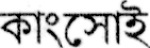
কাংসোই
